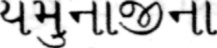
યમુનાજીના
